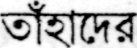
তাঁহাদের
